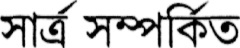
সার্ত্র সম্পর্কিত
